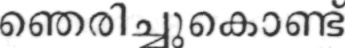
ഞെരിച്ചുകൊണ്ട്
